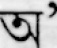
অ'
